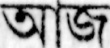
আজ
